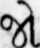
જો
